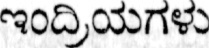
ಇಂದ್ರಿಯಗಳು
